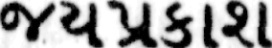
જયપ્રકાશ
